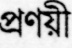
প্রণয়ী
